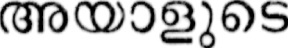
അയാളുടെ
